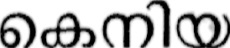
കെനിയ
